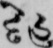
દેહ
